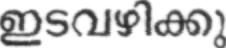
ഇടവഴിക്കു
